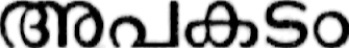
അപകടം
